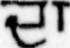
ਦਾ
